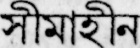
সীমাহীন
